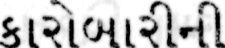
કારોબારીની
